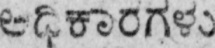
ಅಧಿಕಾರಗಳು
